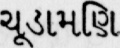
ચૂડામણિ
